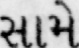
સામે
